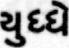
યુધ્ધે
